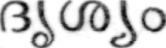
ദൃശ്യം
